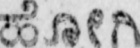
ಹೋಗಿ
